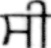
ਸੀ
